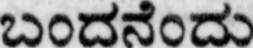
ಬಂದನೆಂದು
